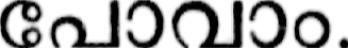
പോവാം.
